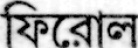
ফিরোল
